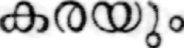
കരയും
